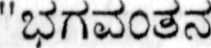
“ಭಗವಂತನ
